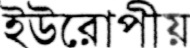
ইউরোপীয়
